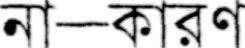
না–কারণ
